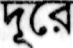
দূরে
